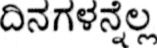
ದಿನಗಳನ್ನೆಲ್ಲ
